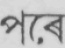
পৰে
